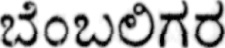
ಬೆಂಬಲಿಗರ
